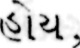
હોય,
